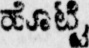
ಹೊಟ್ಟೆ
